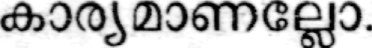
കാര്യമാണല്ലോ.
